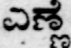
ಎಣ್ಣೆ
